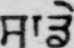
ਸਾਡੇ
